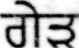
ਗੇੜ
